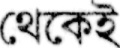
থেকেই
